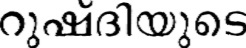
റുഷ്ദിയുടെ
